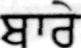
ਬਾਰੇ
